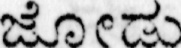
ಜೋಡು
